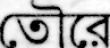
তৌরে
